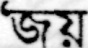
‘জয়
